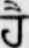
ਹੈ
